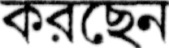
করছেন
